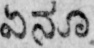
ಏನೂ
